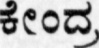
ಕೇಂದ್ರ
